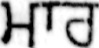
ਮਾਰ
